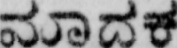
ಮಾದಕ
